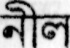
নীল
